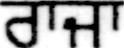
ਰਾਜਾ
